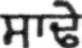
ਸਾਢੇ
